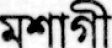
মশাগী
